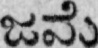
ಜಮೆ
